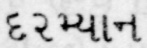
દરમ્યાન
